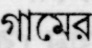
গামের
